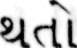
થતો
